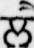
ਲੈ
